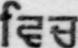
ਵਿਚ
